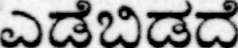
ಎಡೆಬಿಡದೆ
